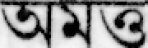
অমত্ত
